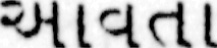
આવતા
